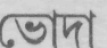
ভোদা
